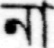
না
